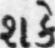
શકે
